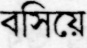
বসিয়ে
